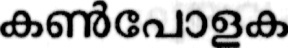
കണ്‍പോളക
